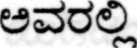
ಅವರಲ್ಲಿ
